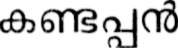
കണ്ടപ്പന്‍
